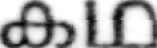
കഥ
